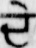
ਦੇ
